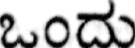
ಒಂದು
